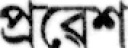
প্রৱেশ
